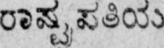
ರಾಷ್ಟ್ರಪತಿಯ
